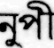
নুপী
